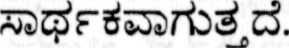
ಸಾರ್ಥಕವಾಗುತ್ತದೆ.
